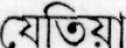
যেতিয়া
